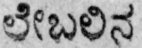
ಲೇಬಲಿನ
